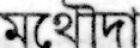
মথৌদা
